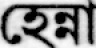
হেন্না
